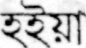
হইয়া
